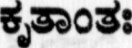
ಕೃತಾಂತಃ
